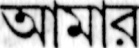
আমার
